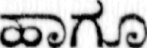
ಹಾಗೂ
